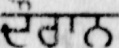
ਦੌਰਾਨ
